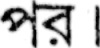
পর।
